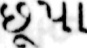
છૂપા
